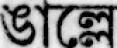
ঙাল্লে
